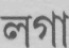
লগা
